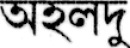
অহলদু
